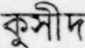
কুসীদ
